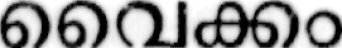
വൈക്കം
